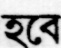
হবে
